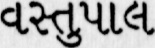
વસ્તુપાલ
